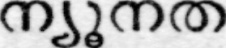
ന്യൂനത
